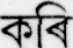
কৰি
